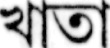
খাতা
